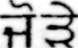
ਜੋੜੇ
